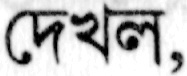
দেখল,
